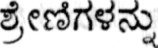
ಶ್ರೇಣಿಗಳನ್ನು
